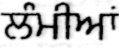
ਲੰਮੀਆਂ
